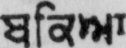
ਬਕਿਆ
